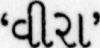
'વીરા'
